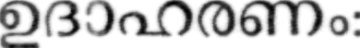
ഉദാഹരണം:
